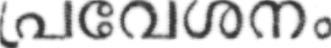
പ്രവേശനം
